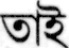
তাই
